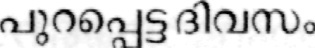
പുറപ്പെട്ടദിവസം
